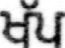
ਖੱਪ-
